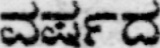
ವರ್ಷದ
